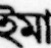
ইমা
